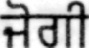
ਜੋਗੀ
